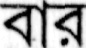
বার
